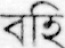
বহি
